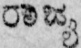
ರಾಜ್ಯ
